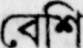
বেশি
